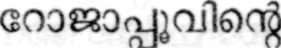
റോജാപ്പൂവിന്റെ
